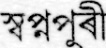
স্বপ্নপুৰী
